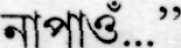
নাপাওঁ..."
